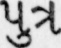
પુત્ર
